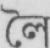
লৈ
